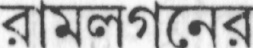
রামলগনের
